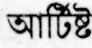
আর্টিষ্ট
